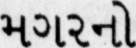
મગરનો
